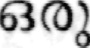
ഒരു
